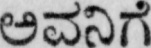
ಅವನಿಗೆ
